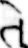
તે
